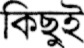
কিছুই
